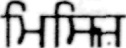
ਮਿਸ਼ਿਜ
